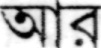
আর
